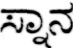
ಸ್ನಾನ
